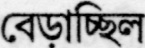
বেড়াচ্ছিল
